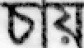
চায়
